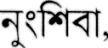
নুংশিবা,
